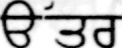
ਉਤਰ
